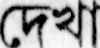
দেখা
